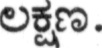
ಲಕ್ಷಣ.
